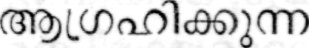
ആഗ്രഹിക്കുന്ന
